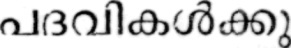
പദവികള്‍ക്കു
